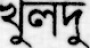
খুলদু
